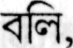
বলি,
